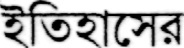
ইতিহাসের
